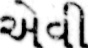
એવી
